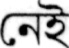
নেই
